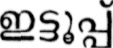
ഇട്ടൂപ്പ്
